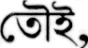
তৌই,
